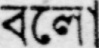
বলো
